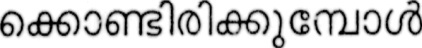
ക്കൊണ്ടിരിക്കുമ്പോള്‍
